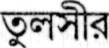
তুলসীর
